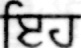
ਇਹ
